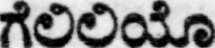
ಗೆಲಿಲಿಯೊ
